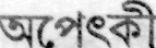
অপেৎকী
